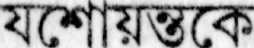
যশোয়ন্তকে
